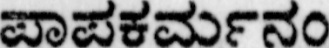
ಪಾಪಕರ್ಮನಂ
